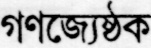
গণজ্যেষ্ঠক
